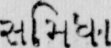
સમિધા
